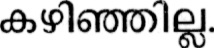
കഴിഞ്ഞില്ല.
